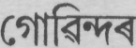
গোৱিন্দৰ
